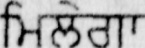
ਮਿਲੇਗਾ
